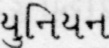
યુનિય
